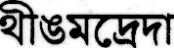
থীঙমদ্রেদা
